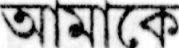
আমাকে
